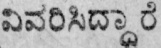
ವಿವರಿಸಿದ್ದಾರೆ
